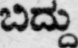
ಬಿದ್ದು
